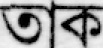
তাক
